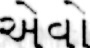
એવો
